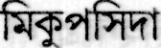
মিকুপসিদা
